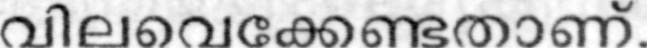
വിലവെക്കേണ്ടതാണ്.
